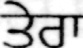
ਤੇਰਾ
